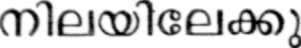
നിലയിലേക്കു
